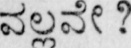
ವಲ್ಲವೇ?
